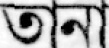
তানা
